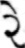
રે
